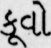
કૂવો
